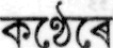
কণ্ঠেৰে
